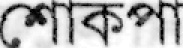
শোকপা
